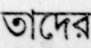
তাদের
